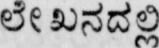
ಲೇಖನದಲ್ಲಿ
